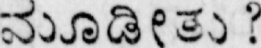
ಮೂಡೀತು?
